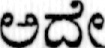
ಅದೇ
